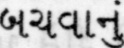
બચવાનું
